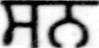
ਸਨ
